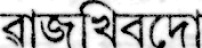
ৱাজখিবদো
